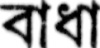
বাধা
